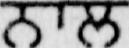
ਨਾਲ
